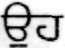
ਉਹ
